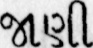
જાણી
